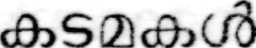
കടമകള്‍
